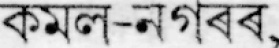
কমল-নগৰৰ,
